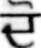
ਦੋ
